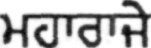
ਮਹਾਰਾਜੇ
